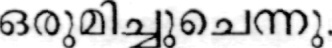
ഒരുമിച്ചുചെന്നു.
